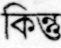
কিন্তু
